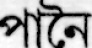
পানৈ
